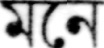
মনে
